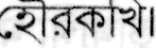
হৌরকখি।
